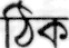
ঠিক
